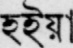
হইয়া
